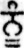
ਨੂੰ
